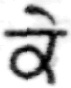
ਕੇ
